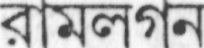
রামলগন
